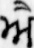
ਐ
